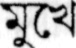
মুখে
